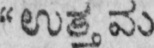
“ಉತ್ತಮ
